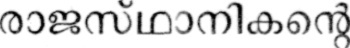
രാജസ്ഥാനികന്റെ
